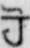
ਹੋ
